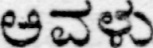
ಅವಳು
